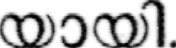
യായി.
